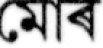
মোৰ
